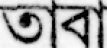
তাবা
